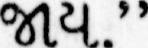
જાય."
